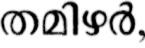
തമിഴര്‍,
